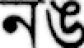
নঙ
